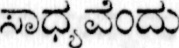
ಸಾಧ್ಯವೆಂದು
